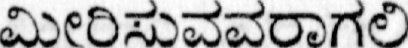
ಮೀರಿಸುವವರಾಗಲಿ
